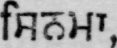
ਸਿਨਮਾ,
